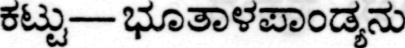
ಕಟ್ಟು-ಭೂತಾಳಪಾಂಡ್ಯನು
